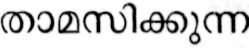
താമസിക്കുന്ന
